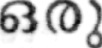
ഒരു
